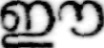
ഈ
